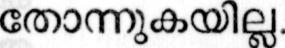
തോന്നുകയില്ല.
